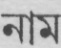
নাম
